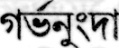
গর্ভনুংদা
